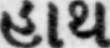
હાથ
